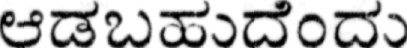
ಆಡಬಹುದೆಂದು
